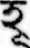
হূ
